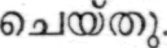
ചെയ്തു.
